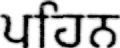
ਪਹਿਨ
